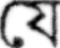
যে
